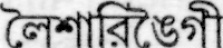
লৈশারিঙৈগী
